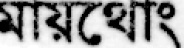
মায়থোং
